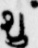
શું
